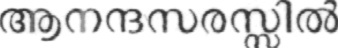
ആനന്ദസരസ്സില്‍
